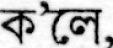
ক'লে,
